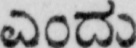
ಎಂದು
